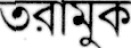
তরামুক
